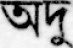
অদু
